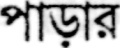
পাড়ার
